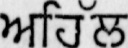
ਅਹਿੱਲ
